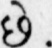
છે.
